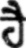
ਹੈ
